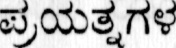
ಪ್ರಯತ್ನಗಳ
